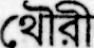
থৌরী
